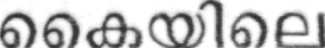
കൈയിലെ
